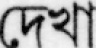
দেখা
